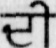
ਦੀ
